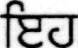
ਇਹ
